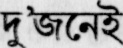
দু'জনেই
